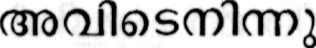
അവിടെനിന്നു
